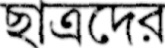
ছাত্রদের
